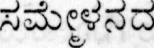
ಸಮ್ಮೇಳನದ
